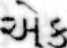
ને
